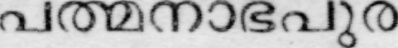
പത്മനാഭപുര
